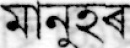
মানুহৰ
